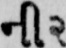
નીર
